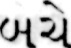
બચે
